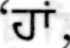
'ਹਾਂ,
